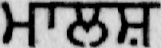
ਮਾਲਸ਼
